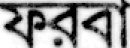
ফরবা
